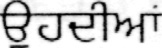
ਉਹਦੀਆਂ
